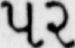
પર
